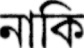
নাকি
